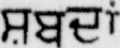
ਸ਼ਬਦਾਂ
